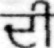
ਦੀ
